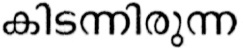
കിടന്നിരുന്ന
